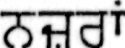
ਨਜ਼ਰਾਂ
